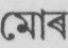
মোৰ
